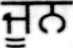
ਜੂਨ
